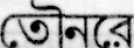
তৌনরে
